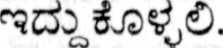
ಇದ್ದುಕೊಳ್ಳಲಿ.
